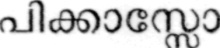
പിക്കാസ്സോ
